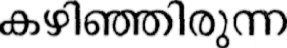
കഴിഞ്ഞിരുന്ന
